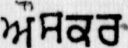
ਔਸਕਰ
